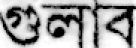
গুলাব
